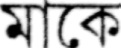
মাকে
